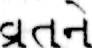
વ્રતને
